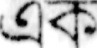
এক
